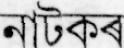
নাটকৰ
